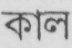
কাল
